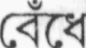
বেঁধে
